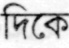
দিকে
